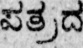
ಪತ್ರದ
